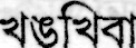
খঙখিবা
